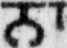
ਨਾ
